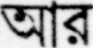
আর
